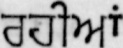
ਰਹੀਆਂ
